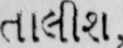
તાલીશ,
